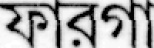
ফারগা
